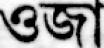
ওজা
